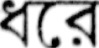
ধরে
